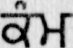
ਕੰਮ
